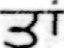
ਤਾਂ
